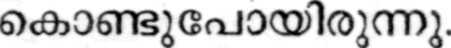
കൊണ്ടുപോയിരുന്നു.
